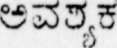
ಅವಶ್ಯಕ
